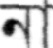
না
